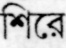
শিরে
